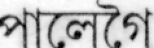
পালেগৈ
